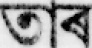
তাৰ
